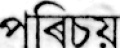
পৰিচয়
